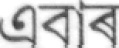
এবাৰ
